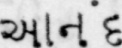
આનંદ
